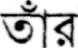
তাঁর
